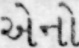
એનો
